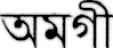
অমগী
